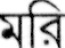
মরি
